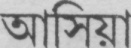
আসিয়া
